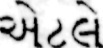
એટલે
